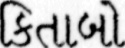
કિતાબો
